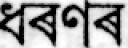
ধৰণৰ
